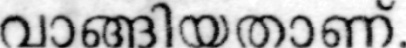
വാങ്ങിയതാണ്.
